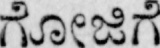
ಗೋಜಿಗೆ
